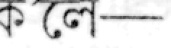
ক'লে-
